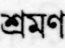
শ্রমণ
